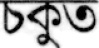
চকুত
